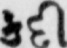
કદી
